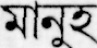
মানুহ
